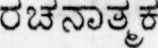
ರಚನಾತ್ಮಕ
